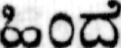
ಹಿಂದೆ
